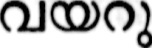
വയറു
